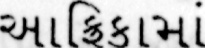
આફ્રિકામાં
